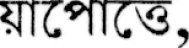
য়াপোত্তে,
